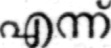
എന്ന്
